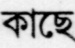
কাছে
